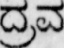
ದ್ರವ
